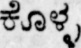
ಕೊಳ್ಳ
